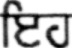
ਇਹ
